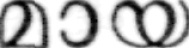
മായ
